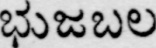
ಭುಜಬಲ
